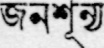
জনশূন্য
